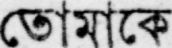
তোমাকে
